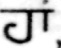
ਹਾਂ,
